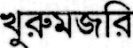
খুরুমজরি
